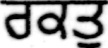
ਰਕਤੁ
